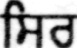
ਸਿਰ
